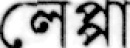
লেপ্পা
